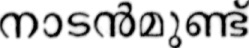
നാടന്‍മുണ്ട്
